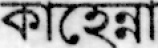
কাহেন্না
